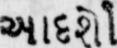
આદર્શો
